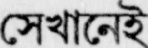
সেখানেই
